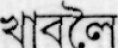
খাবলৈ
